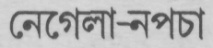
নেগেলা-নপচা
